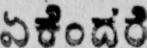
ಏಕೆಂದರೆ
